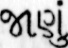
જાણું
